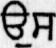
ਉਸ
